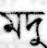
মদু
